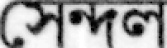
সেন্দল
